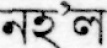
নহ'ল
